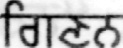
ਗਿਣਨ
